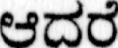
ಆದರೆ
